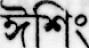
ঈশিং
